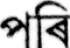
পৰি
